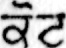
ਕੋਟ
